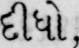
દીધો,
